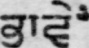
ਭਾਵੇਂ
